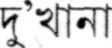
দু’খানা
